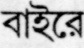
বাইরে
